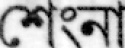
শেংনা
